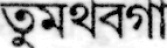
তুমথবগা
